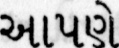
આપણે
